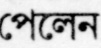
পেলেন
